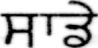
ਸਾਡੇ
